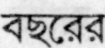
বছরের
